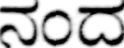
ನಂದ
